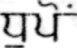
ਧੁਪੋਂ
